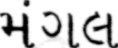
મંગલ
